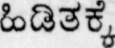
ಹಿಡಿತಕ್ಕೆ
